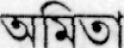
অমিতা
